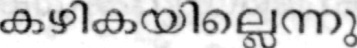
കഴികയില്ലെന്നു
